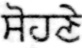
ਸੋਹਣੇ
